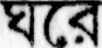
ঘরে
